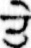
ਤੇ
